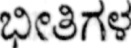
ಭೀತಿಗಳ
